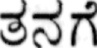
ತನಗೆ
